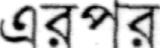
এরপর
